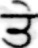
ਤੇ
